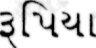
રૂપિયા
